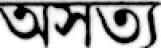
অসত্য
